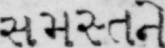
સમસ્તને
